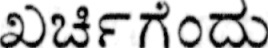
ಖರ್ಚಿಗೆಂದು
